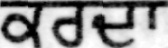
ਕਰਦਾ
